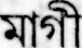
মাগী
